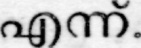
എന്ന്.
